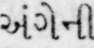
અંગેની
